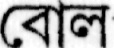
বোল
